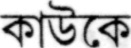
কাউকে
